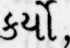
કર્યો,
